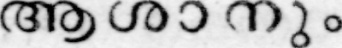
ആശാനും
